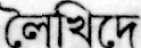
লৈখিদে
